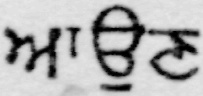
ਆਉਣ
